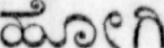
ಹೋಗಿ
